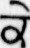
ਕੇ
